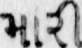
મારી
